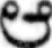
ಆ
